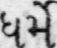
ધર્મે
